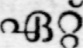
ഏറ്റ്
